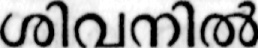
ശിവനില്‍
